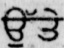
ਉੱਤੇ
